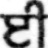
ਈ
